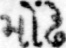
મોંઢે
